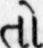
તો
